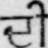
ਦੀ
